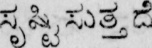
ಸೃಷ್ಟಿಸುತ್ತದೆ
